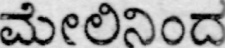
ಮೇಲಿನಿಂದ
